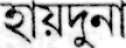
হায়দুনা
